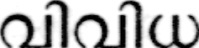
വിവിധ
